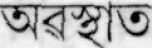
অৱস্থাত
